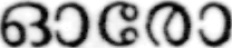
ഓരോ
